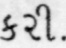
કરી.
